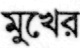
মুখের
